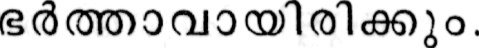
ഭര്‍ത്താവായിരിക്കും.
